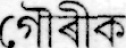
গৌৰীক
